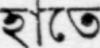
হাতে
